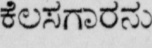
ಕೆಲಸಗಾರನು
